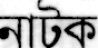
নাটক
